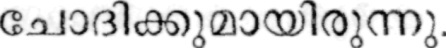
ചോദിക്കുമായിരുന്നു.
